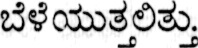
ಬೆಳೆಯುತ್ತಲಿತ್ತು.
